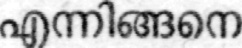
എന്നിങ്ങനെ
